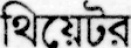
থিয়েটর
